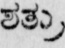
ಶತ್ರು
